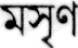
মসৃণ
